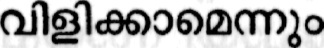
വിളിക്കാമെന്നും
